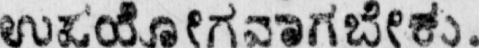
ಉಪಯೋಗವಾಗಬೇಕು.
